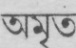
অমৃত
